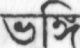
ভঙ্গি
